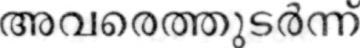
അവരെത്തുടര്‍ന്ന്
